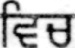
ਵਿਚ
